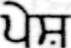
ਪੇਸ਼
